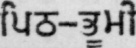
ਪਿਠ-ਭੂਮੀ
